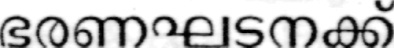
ഭരണഘടനക്ക്
